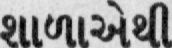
શાળાએથી
